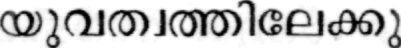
യുവത്വത്തിലേക്കു
